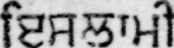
ਇਸਲਾਮੀ
